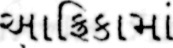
આફ્રિકામાં
